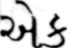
એક
